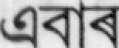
এবাৰ
